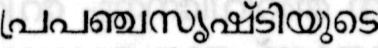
പ്രപഞ്ചസൃഷ്ടിയുടെ
